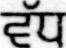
ਵੱਧ
